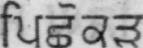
ਪਿਛੋਕੜ
